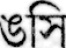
ঙসি
